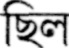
ছিল
